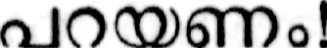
പറയണം!
